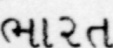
ભારત
